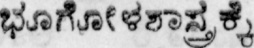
ಭೂಗೋಳಶಾಸ್ತ್ರಕ್ಕೆ
